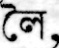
লৈ,
